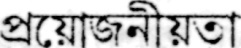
প্রয়োজনীয়তা
